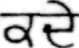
ਕਦੇ
